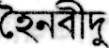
হৈনবীদু
